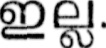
ഇല്ല
